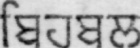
ਬਿਹਬਲ
